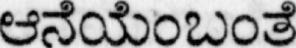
ಆನೆಯೆಂಬಂತೆ
